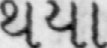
થયા
